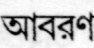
আবরণ
